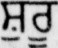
ਸ਼ੁਰੂ
